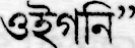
ওইগনি”
